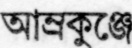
আম্রকুঞ্জে
